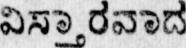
ವಿಸ್ತಾರವಾದ
